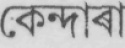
কেন্দাৰা
